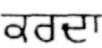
ਕਰਦਾ
